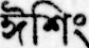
ঈশিং
